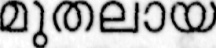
മുതലായ
